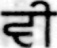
ਵੀ
